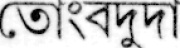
তোংবদুদা
